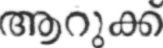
ആറുക്ക്
